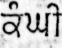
ਕੰਘੀ
